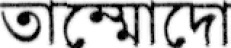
তাম্মোদো
